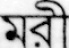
মরী
